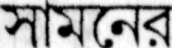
সামনের
